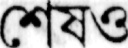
শেষও
